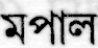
মপাল
